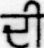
ਦੀ
